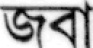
জবা
